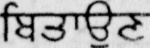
ਬਿਤਾਉਣ
